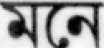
মনে
